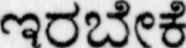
ಇರಬೇಕೆ
